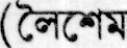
(লৈশেম
